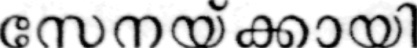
സേനയ്ക്കായി
